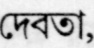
দেবতা,
